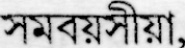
সমবয়সীয়া,
